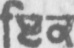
ਇਕ
